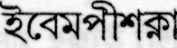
ইবেমপীশক্না
